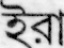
ইরা
